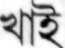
খাই
